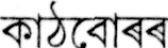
কাঠবোৰৰ
